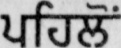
ਪਹਿਲੋਂ
